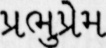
પ્રભુપ્રેમ
